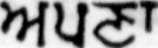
ਅਪਣਾ
